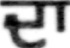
ਦਾ
